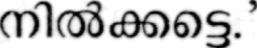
നില്‍ക്കട്ടെ.'
